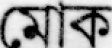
মোক
